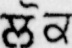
ਲੋਕ
